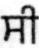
ਸੀ
